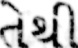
તેથી
